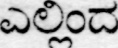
ಎಲ್ಲಿಂದ
